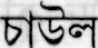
চাউল
